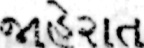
જાહેરાત
